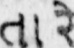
તારે
